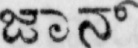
ಜಾನ್
